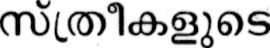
സ്ത്രീകളുടെ
